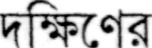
দক্ষিণের
